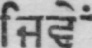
ਜਿਵੇਂ
